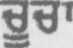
ਚੂਚਾ
